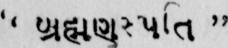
“બ્રહ્મણસ્પતિ”
